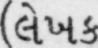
(લેખક
